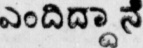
ಎಂದಿದ್ದಾನೆ
